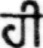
ਹੀ
